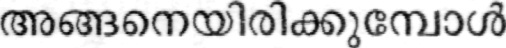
അങ്ങനെയിരിക്കുമ്പോള്‍
